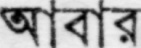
আবার
